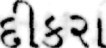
દીકરા
